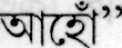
আহোঁ"
